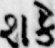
શકે
